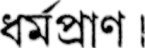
ধর্মপ্রাণ।
